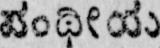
ಪಂಥೀಯ
